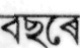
বছৰে
